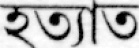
হত্যাত
